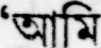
‘আমি
